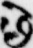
છે?
